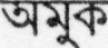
অমুক
